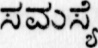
ಸಮಸ್ಯೆ
